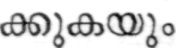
ക്കുകയും
